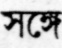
সঙ্গে
